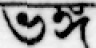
ভঙ্গ
